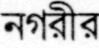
নগরীর
